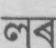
লৰ
